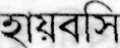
হায়বসি
